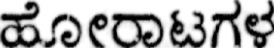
ಹೋರಾಟಗಳ
